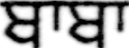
ਬਾਬਾ
